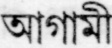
আগামী
